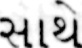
સાથે
